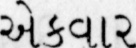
એકવાર
